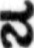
ನ
